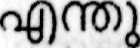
എന്തു
